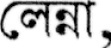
লেন্না,
